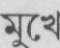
মুখে
